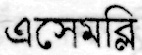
এসেমব্লি
